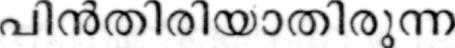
പിന്‍തിരിയാതിരുന്ന
